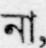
না,
